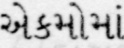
એકમોમાં
